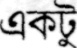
একটু
